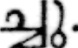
ച്ചു.
